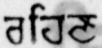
ਰਹਿਣ
